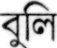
বুলি
